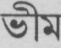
ভীম
